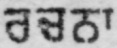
ਰਚਨਾ
